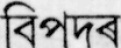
বিপদৰ
